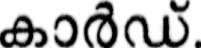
കാര്‍ഡ്.
